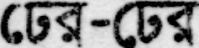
ঢের-ঢের
